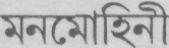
মনমোহিনী
